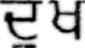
ਦੁਖ
